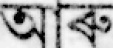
আৰু
